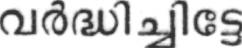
വര്‍ദ്ധിച്ചിട്ടേ
